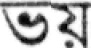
ভয়
